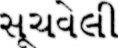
સૂચવેલી
